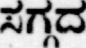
ಸಗ್ಗದ
